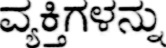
ವ್ಯಕ್ತಿಗಳನ್ನು
